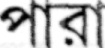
পারা
